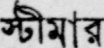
স্টীমার
